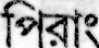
পিরাং
